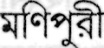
মণিপুরী
